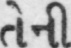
તેની
